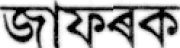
জাফৰক
